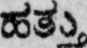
ಹತ್ತು
